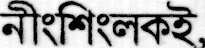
নীংশিংলকই,
